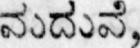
ಮದುವೆ,
